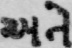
અને
